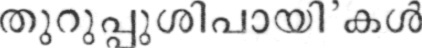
തുറുപ്പുശിപായി'കള്‍
